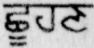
ਛੂਹਣ
